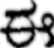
ಈ
